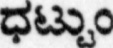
ಧಟ್ಟುಂ
